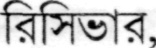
রিসিভার,
